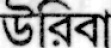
উরিবা
